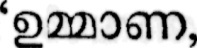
‘ഉമ്മാണ,
